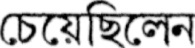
চেয়েছিলেন
